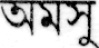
অমসু
